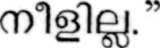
നീളില്ല."
